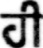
ਹੀ
